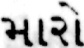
મારો
